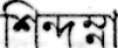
শিন্দম্না
